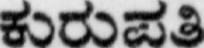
ಕುರುಪತಿ
